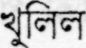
খুলিল
